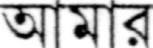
আমার
